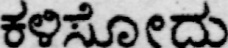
ಕಳಿಸೋದು
